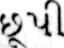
છૂપી
